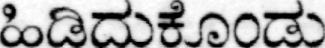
ಹಿಡಿದುಕೊಂಡು
